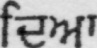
ਦਿਆ
